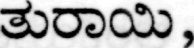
ತುರಾಯಿ,
